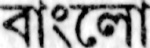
বাংলো
